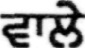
ਵਾਲੇ
